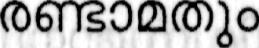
രണ്ടാമതും
